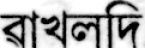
ৱাখলদি
